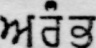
ਅਰੰਭ
